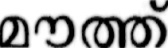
മൌത്ത്
